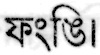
ফংঙি।
